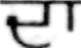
ਦਾ
